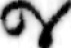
જ
